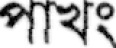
পাখং
